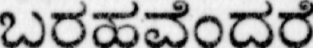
ಬರಹವೆಂದರೆ
